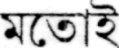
মতোই
